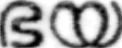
ഭയ
